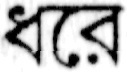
ধরে
